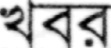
খবর
